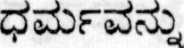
ಧರ್ಮವನ್ನು
